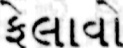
ફેલાવો
